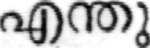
എന്തു
